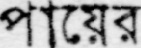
পায়ের
